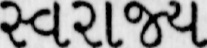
સ્વરાજ્ય
